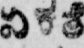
ಏಕತೆ
